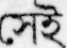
সেই
